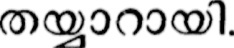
തയ്യാറായി.
